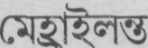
মেহ্ৰাইলন্ত
